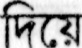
দিয়ে
